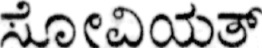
ಸೋವಿಯತ್
